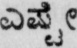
ಎಷ್ಟೇ
